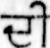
ਦੀ
